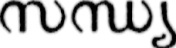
സന്ധ്യ
